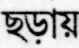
ছড়ায়
